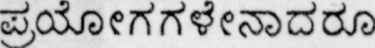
ಪ್ರಯೋಗಗಳೇನಾದರೂ
